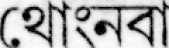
থোংনবা
